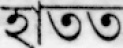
হাতত
